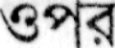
ওপর
